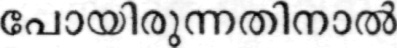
പോയിരുന്നതിനാല്‍
